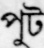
পুট
